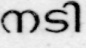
നടി
